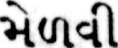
મેળવી
